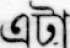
এটা
